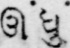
ઊંધું
